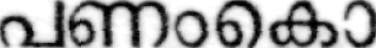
പണംകൊ
